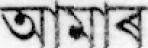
আমাৰ
